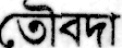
তৌবদা
